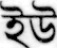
ইউ
